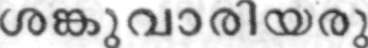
ശങ്കുവാരിയരു
